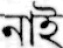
নাই
